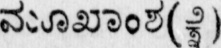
ಮೂಖಾಂಶ(೨/೩)
